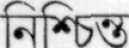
নিশ্চিন্ত
